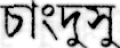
চাংদুসু
